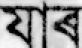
যাৰ
